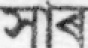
সাৰ
